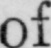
of
